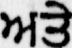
ਅਤੇ
